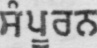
ਸੰਪੂਰਨ
